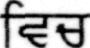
ਵਿਚ
